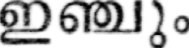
ഇഞ്ചും
